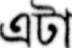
এটা
